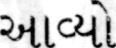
આવ્યો
